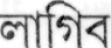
লাগিব
